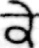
ਕੇ
